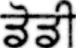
ਡੋਡੀ
